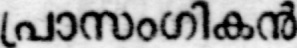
പ്രാസംഗികന്‍
